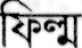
ফিল্ম
